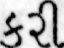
કરી
